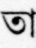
তা
